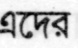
এদের
